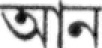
আন
